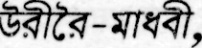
উরীরৈ-মাধবী,
